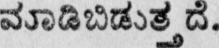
ಮಾಡಿಬಿಡುತ್ತದೆ.
